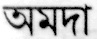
অমদা
